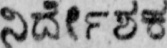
ನಿರ್ದೇಶಕ
